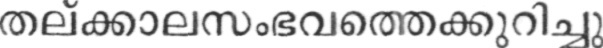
തല്ക്കാലസംഭവത്തെക്കുറിച്ചു
